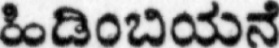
ಹಿಡಿಂಬಿಯನೆ
